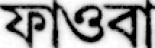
ফাওবা
